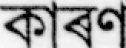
কাৰণ
